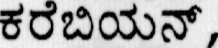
ಕರೆಬಿಯನ್,
